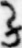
કે
